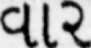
વાર
